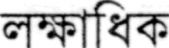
লক্ষাধিক
